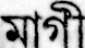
মাগী
